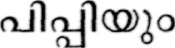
പിപ്പിയും
